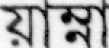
য়াম্না
